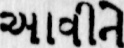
આવીને
